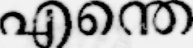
എന്തെ
